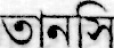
তানসি
